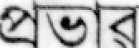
প্রভাৱ
